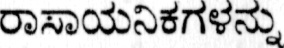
ರಾಸಾಯನಿಕಗಳನ್ನು
